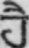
ਹੈ
